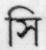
সি
